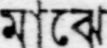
মাঝে
